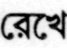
রেখে
